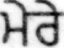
ਮੇਰੇ
